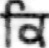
ਕਿ
